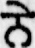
ਨੇ
